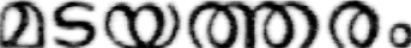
മടയത്തരം
